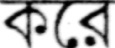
করে
